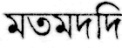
মতমদদি
